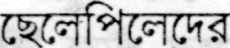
ছেলেপিলেদের
